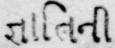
જ્ઞાતિની
